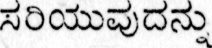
ಸರಿಯುವುದನ್ನು
